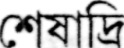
শেষাদ্রি
